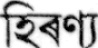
হিৰণ্য
